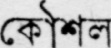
কৌশল
